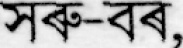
সৰু-বৰ,
